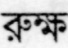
রুক্ষ
